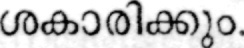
ശകാരിക്കും.
